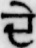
ਦੇ
